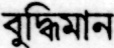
বুদ্ধিমান
